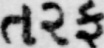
તરફ
